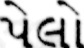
પેલો
